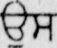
ਉਸ
